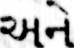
અને
